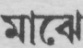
মাঝে
